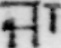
ਜਾ
